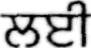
ਲਈ
